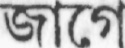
জাগে
